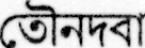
তৌনদবা
